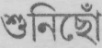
শুনিছোঁ
